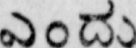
ಎಂದು
